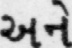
અને
